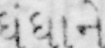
ધંધાને
